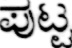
ಪುಟ್ಟ
